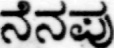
ನೆನಪು
